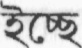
ইচ্ছে
